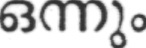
ഒന്നും
